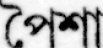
পৈশা
